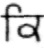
ਕਿ
